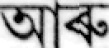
আৰু
